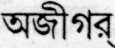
অজীগর্
